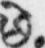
છે.
